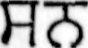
ਸਨ
